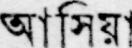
আসিয়া
